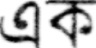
এক
